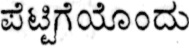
ಪೆಟ್ಟಿಗೆಯೊಂದು
